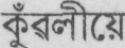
কুঁৱলীয়ে
